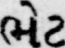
ભેટ
